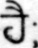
ਹੈ;
